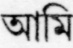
আমি
